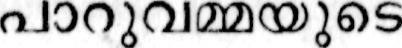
പാറുവമ്മയുടെ
